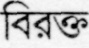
বিরক্ত
